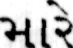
મારે
